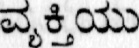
ವ್ಯಕ್ತಿಯು
